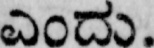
ಎಂದು.
